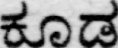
ಕೂಡ
